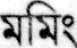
মমিং
